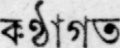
কণ্ঠাগত
